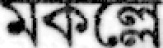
মকল্লে
